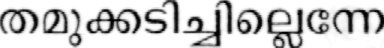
തമുക്കടിച്ചില്ലെന്നേ
